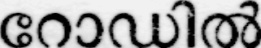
റോഡില്‍
